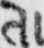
તો
